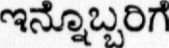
ಇನ್ನೊಬ್ಬರಿಗೆ
